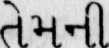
તેમની
